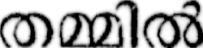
തമ്മില്‍
